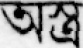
অস্ত্র
